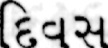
દિવસ
